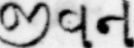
જીવન
